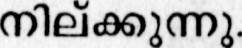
നില്ക്കുന്നു.
